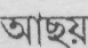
আছয়
